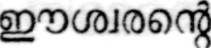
ഈശ്വരന്റെ
